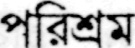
পরিশ্রম
